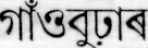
গাঁওবুঢ়াৰ
